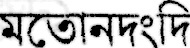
মতোনদংদি
